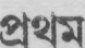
প্ৰথম
